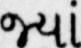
જ્યાં
